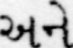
અને
